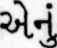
એનું
